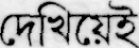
দেখিয়েই
